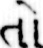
તો
